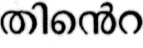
തിന്റെ
